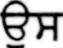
ਉਸ
